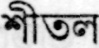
শীতল
